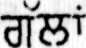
ਗੱਲਾਂ
